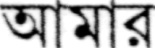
আমার
